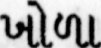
ખોળા
